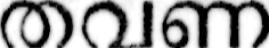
തവണ
